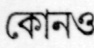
কোনও
